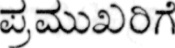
ಪ್ರಮುಖರಿಗೆ
